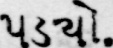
પડ્યો.
